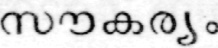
സൌകര്യം
